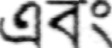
এবং
